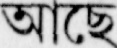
আছে
